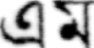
এম
